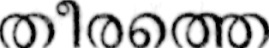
തീരത്തെ
